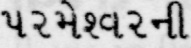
પરમેશ્વરની
